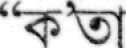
"ক'তা
